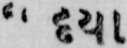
"દયા
